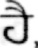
ਹੈ,
